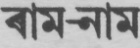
ৰাম-নাম
